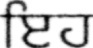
ਇਹ
